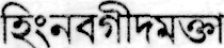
হিংনবগীদমক্তা
